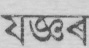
যজ্ঞৰ
